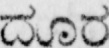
ದೂರ
